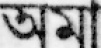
অমা
